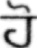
ਹੋ
